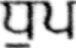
ਧੁਪ
